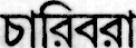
চারিবরা
